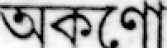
অকণো
